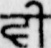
ਵੀ
